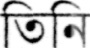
তিনি
